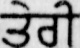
ਤੇਰੀ
